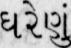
ઘરેણું
